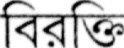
বিরক্তি
